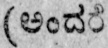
(ಅಂದರೆ
